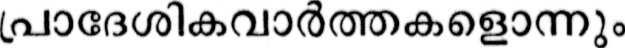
പ്രാദേശികവാര്‍ത്തകളൊന്നും
